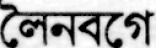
লৈনবগে
